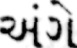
અંગે
